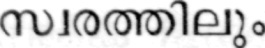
സ്വരത്തിലും
